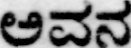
ಅವನ
